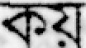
কয়
